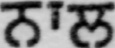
ਨਾਲ
